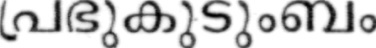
പ്രഭുകുടുംബം
